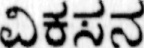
ವಿಕಸನ
